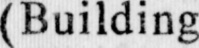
(Building
